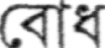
বোধ
